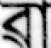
ৱা
